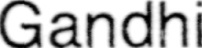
Gandhi
